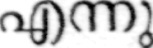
എന്നു
